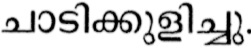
ചാടിക്കുളിച്ചു.
